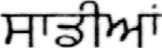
ਸਾਡੀਆਂ
